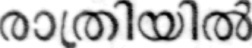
രാത്രിയില്‍
